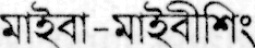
মাইবা-মাইবীশিং
